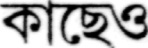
কাছেও
